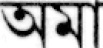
অমা
